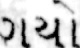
ગયો
